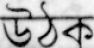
উঠক
